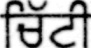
ਚਿੱਟੀ
